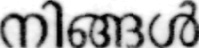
നിങ്ങള്‍
